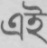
এই
